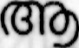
ആ
